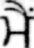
ਮੈਂ
